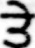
ਤੇ
